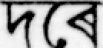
দৰে
